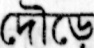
দৌড়ে
